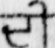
ਦੀ
